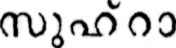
സുഹ്റാ
